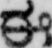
ಈ
